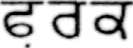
ਫ਼ਰਕ
